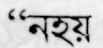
"নহয়
